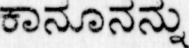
ಕಾನೂನನ್ನು
